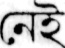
নেই
